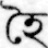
হৈ
